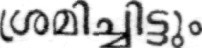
ശ്രമിച്ചിട്ടും
